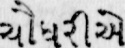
ચૌધરીએ
